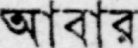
আবার
